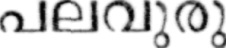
പലവുരു
